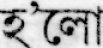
হ'লো
